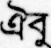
ঐবু
